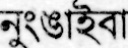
নুংঙাইবা
